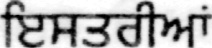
ਇਸਤਰੀਆਂ
